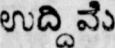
ಉದ್ದಿಮೆ
